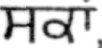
ਸਕਾਂ,
